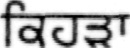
ਕਿਹੜਾ
